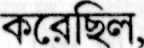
করেছিল,
